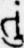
તું
